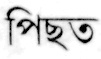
পিছত
